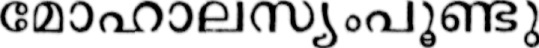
മോഹാലസ്യംപൂണ്ടു
